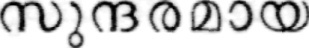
സുന്ദരമായ
